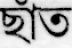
ছাঁত
